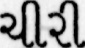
ચીરી
